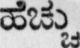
ಹೆಚ್ಚು
